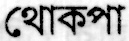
থোকপা
